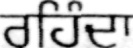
ਰਹਿੰਦਾ
